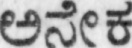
ಅನೇಕ
